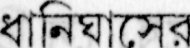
ধানিঘাসের
